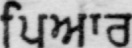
ਪਿਆਰ
